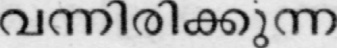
വന്നിരിക്കുന്ന
